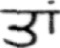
ਤਾਂ
